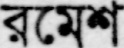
রমেশ
